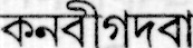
কনবীগদবা
